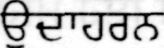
ਉਦਾਹਰਨ
